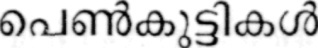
പെണ്‍കുട്ടികള്‍
